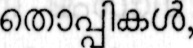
തൊപ്പികള്‍,
